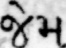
જેમ
